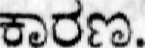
ಕಾರಣ.
